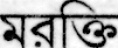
মরক্তি
